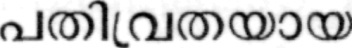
പതിവ്രതയായ
